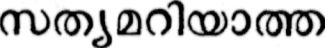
സത്യമറിയാത്ത
